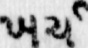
ખર્ય
